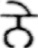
ਨੇ
